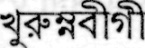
খুরুম্বগী
